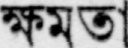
ক্ষমতা
